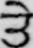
ਤੇ
